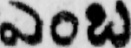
ಎಂಬ
